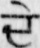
ਦੇ
